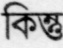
কিন্তু
